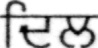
ਦਿਲ
